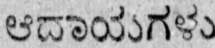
ಆದಾಯಗಳು
